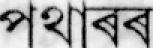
পথাৰৰ
